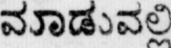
ಮಾಡುವಲ್ಲಿ
